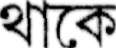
থাকে
